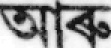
আৰু
